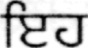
ਇਹ
